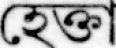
হেক্তা
